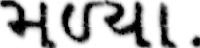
મળ્યા.
